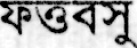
ফত্তবসু
